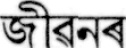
জীৱনৰ
